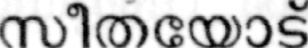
സീതയോട്
